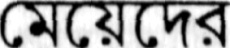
মেয়েদের
